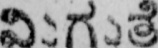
ಮಿಗುತೆ
